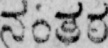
ನಂತರ
